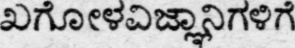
ಖಗೋಳವಿಜ್ಞಾನಿಗಳಿಗೆ
